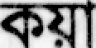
কয়া
